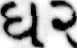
ઘર
